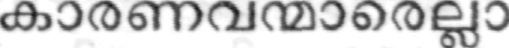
കാരണവന്മാരെല്ലാ
